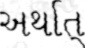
અર્થાત્
